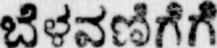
ಬೆಳವಣಿಗೆಗೆ
